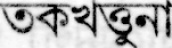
তকখত্তুনা
